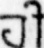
ਹੀ
